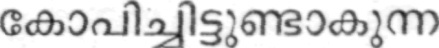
കോപിച്ചിട്ടുണ്ടാകുന്ന
